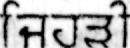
ਜਿਹੜੀ
